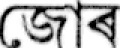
জোৰ
